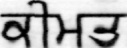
ਕੀਮਤ
